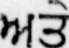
ਅਤੇ
